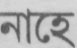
নাহে
